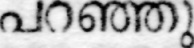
പറഞ്ഞു
